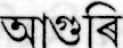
আগুৰি
